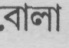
বোলা
